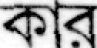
কার
